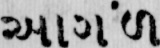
આગંળ
